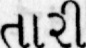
તારી
